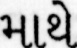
માથે
